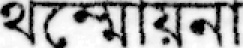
থম্মোয়না
